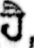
ਹੈ,
